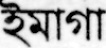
ইমাগা
